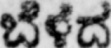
ಬೆಳೆದ
